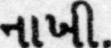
નાખી.
